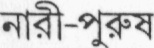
নারী-পুরুষ
